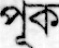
পূক
